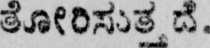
ತೋರಿಸುತ್ತದೆ.
